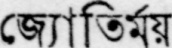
জ্যোতির্ময়
